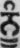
ਨੂੰ
